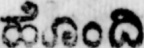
ಹೊಂದಿ
